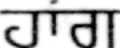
ਹਾਂਗ
